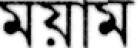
ময়াম
